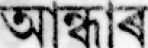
আন্ধাৰ
